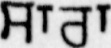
ਸਾਰਾ
